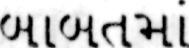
બાબતમાં
